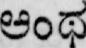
ಅಂಥ
